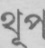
থূপ
